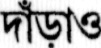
দাঁড়াও
